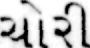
ચોરી
